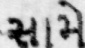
સામે
